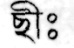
ছীঃ
